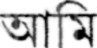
আমি
